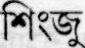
শিংজু
